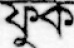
ফুক
